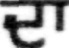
ਦਾ
